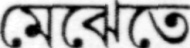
মেঝেতে
